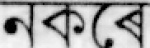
নকৰে
